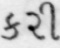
કરી
